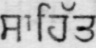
ਸਾਹਿੱਤ
